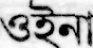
ওইনা
